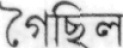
গৈছিল
